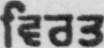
ਵਿਰਤ
